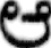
ಆ
